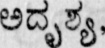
ಅದೃಶ್ಯ,
